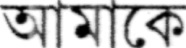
আমাকে
